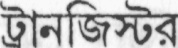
ট্রানজিস্টর
